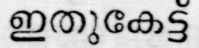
ഇതുകേട്ട്
